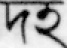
দহ
